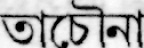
তাচৌনা
